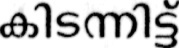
കിടന്നിട്ട്
